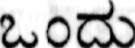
ಒಂದು
